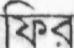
ফির
